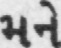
મને
